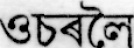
ওচৰলৈ
